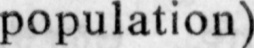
population)
